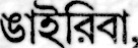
ঙাইরিবা,
